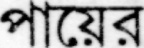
পায়ের
